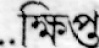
...ক্ষিপ্ত
